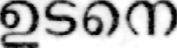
ഉടനെ
